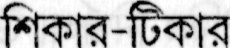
শিকার-টিকার
